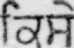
ਕਿਸੇ
